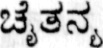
ಚೈತನ್ಯ
